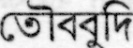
তৌববুদি
